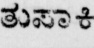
ತುಪಾಕಿ
